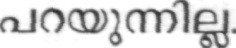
പറയുന്നില്ല.
